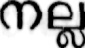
നല്ല
